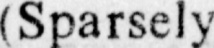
(Sparsely
